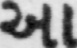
આ
